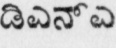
ಡಿಎನ್‌ಎ
